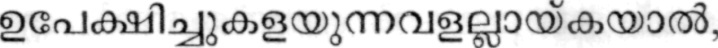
ഉപേക്ഷിച്ചുകളയുന്നവളല്ലായ്കയാല്‍,
